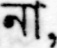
না,
